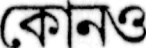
কোনও
